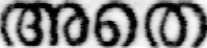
അതെ
